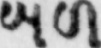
બળ
